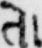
તો
